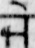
ਜੇ
